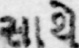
સાથે
